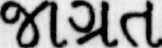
જાગ્રત
